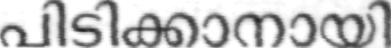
പിടിക്കാനായി
